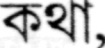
কথা,
